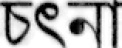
চৎনা
